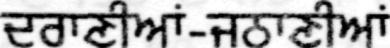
ਦਰਾਣੀਆਂ-ਜਠਾਣੀਆਂ
